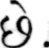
છે.
